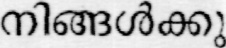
നിങ്ങള്‍ക്കു
